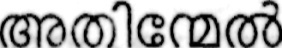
അതിന്മേല്‍
